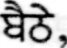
ਬੈਠੇ,
